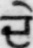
ਦੇ
